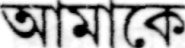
আমাকে
